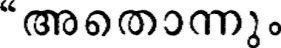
"അതൊന്നും
